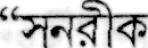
“সনরীক
